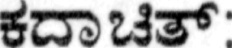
ಕದಾಚಿತ್:
